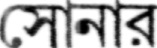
সোনার
